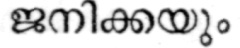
ജനിക്കയും
